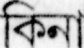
কিনা
